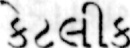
કેટલીક
